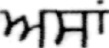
ਅਸਾਂ
